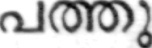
പത്തു
